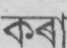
কৰা
